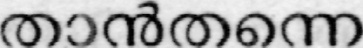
താന്‍തന്നെ
